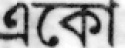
একো
